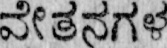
ವೇತನಗಳ
